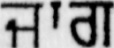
ਜਾਗ
